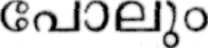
പോലും
